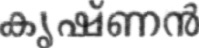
കൃഷ്ണന്‍
